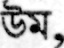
উম,
